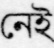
নেই
